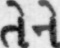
તેને
